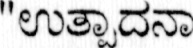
“ಉತ್ಪಾದನಾ
